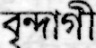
বৃন্দাগী
